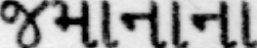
જમાનાના
